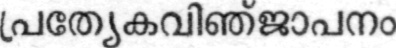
പ്രത്യേകവിഞ്ജാപനം
